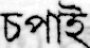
চপাই
